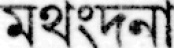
মথংদনা
